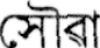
সৌৱা
